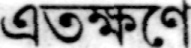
এতক্ষণে
